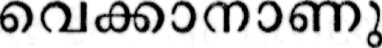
വെക്കാനാണു
